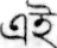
এই
